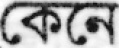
কেনে
